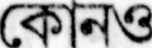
কোনও
